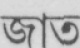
জাত
